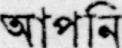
আপনি
